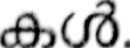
കള്‍.
